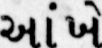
આંખે
